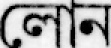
লোন
